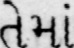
તેમાં
